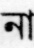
না
